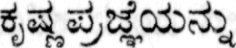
ಕೃಷ್ಣಪ್ರಜ್ಞೆಯನ್ನು
